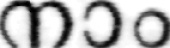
നാം
